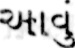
આવું
